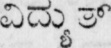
ವಿದ್ಯುತ್
